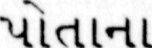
પોતાના
